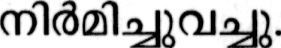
നിര്‍മിച്ചുവച്ചു.
